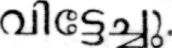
വിട്ടേച്ചു.
